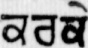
ਕਰਕੇ
